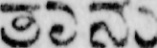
ತಾನು
